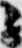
કે
